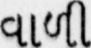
વાળી
